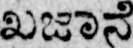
ಖಜಾನೆ
